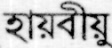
হায়বীয়ু
